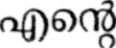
എന്റെ
